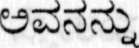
ಅವನನ್ನು
